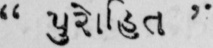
“પુરોહિત"
